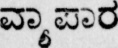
ವ್ಯಾಪಾರ
